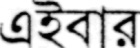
এইবার
